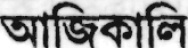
আজিকালি
